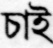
চাই
